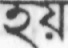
হয়
